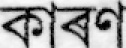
কাৰণ
